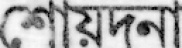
শোয়দনা
